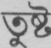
তুষ্ট
